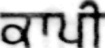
ਕਾਪੀ
